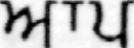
ਆਪ
